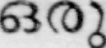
ഒരു
